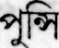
পুন্সি
